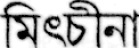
মিৎচীনা
